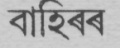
বাহিৰৰ
